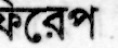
ফিরেপ
